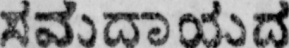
ಸಮದಾಯದ
